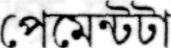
পেমেন্টটা
